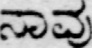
ನಾವು
